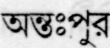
অন্তঃপুর
